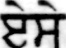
ਏਸੇ
